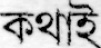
কথাই
